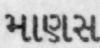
માણસ
